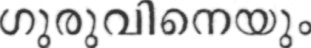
ഗുരുവിനെയും
